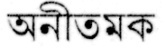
অনীতমক
